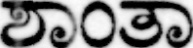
ಶಾಂತಾ
